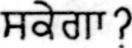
ਸਕੇਗਾ?
